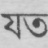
যত
